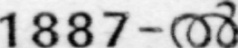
1887-ല്‍
